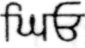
ਘਿਓ
